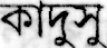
কাদুসু
